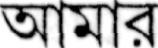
আমার
